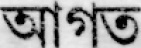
আগত
